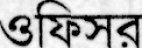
ওফিসর
